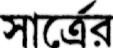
সার্ত্রের
